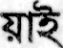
য়াই
